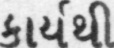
કાર્યથી
